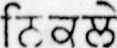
ਨਿਕਲੇ
